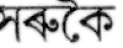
সৰুকৈ
